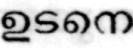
ഉടനെ
